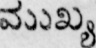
ಮುಖ್ಯ
